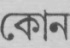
কোন
